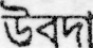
উবদা
